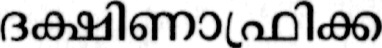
ദക്ഷിണാഫ്രിക്ക
